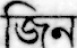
জিন
